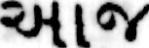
આજ
